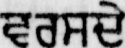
ਵਰਸਦੇ
